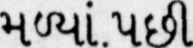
મળ્યાં.પછી
